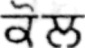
ਕੋਲ
